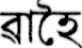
ৱাহৈ
